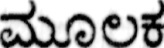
ಮೂಲಕ
